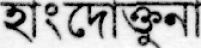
হাংদোক্তুনা
